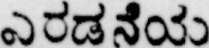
ಎರಡನೆಯ
